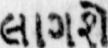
લાગશે
